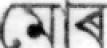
মোৰ
